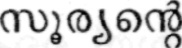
സൂര്യന്റെ
